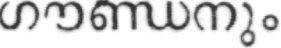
ഗൗണ്ഡനും
